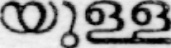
യുള്ള
